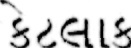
કેટલાક
